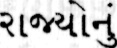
રાજ્યોનું
